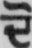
ਦੋ
